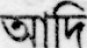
আদি
